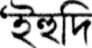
'ইহুদি
